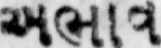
અભાવ
